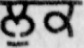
ਲੁਕ
